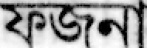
ফজনা
